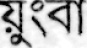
য়ুংবা
